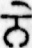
ਨੇ
